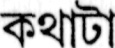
কথাটা
